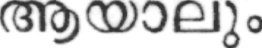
ആയാലും
